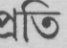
প্ৰতি
